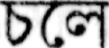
চলে
